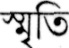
স্মৃতি
